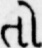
તો
